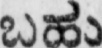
ಬಹು
